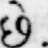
છે.
